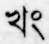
খং
